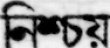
নিশ্চয়
